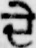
ਦੇ
